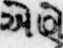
એણે
